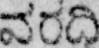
ವರದಿ
